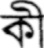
কী
